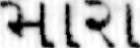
મારા
